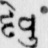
દેવું
